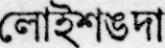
লোইশঙদা
